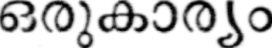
ഒരുകാര്യം
